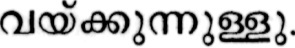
വയ്ക്കുന്നുള്ളു.
